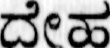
ದೇಹ
